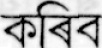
কৰিব
